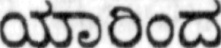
ಯಾರಿ೦ದ
